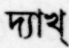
দ্যাখ্
